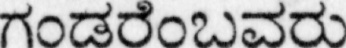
ಗಂಡರೆಂಬವರು
